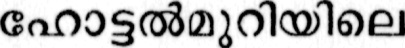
ഹോട്ടല്‍മുറിയിലെ
